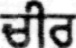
ਚੀਰ
